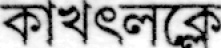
কাখৎলক্লে
